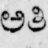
ಅತಿ
